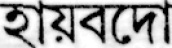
হায়বদো
